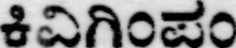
ಕಿವಿಗಿಂಪಂ
